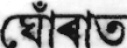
ঘোঁৰাত
